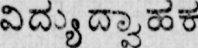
ವಿದ್ಯುದ್ವಾಹಕ
